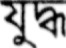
যুদ্ধ
